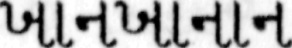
ખાનખાનાન
